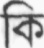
কি
